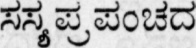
ಸಸ್ಯಪ್ರಪಂಚದ
